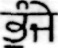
ਭੁੰਜੇ
